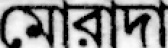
মোরাদা
